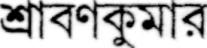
শ্রাবণকুমার
